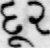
દૂર
